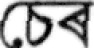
চেৰ
